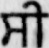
ਸੀ
